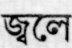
জ্বলে
